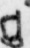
તું
